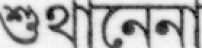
শুথানেনা
